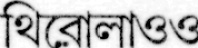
থিরোলাওও
